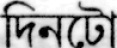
দিনটো
